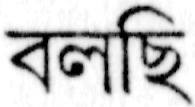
বলছি
